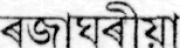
ৰজাঘৰীয়া
